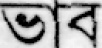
ভাব
